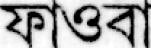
ফাওবা
